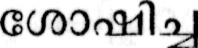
ശോഷിച്ച
